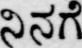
ನಿನಗೆ
